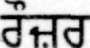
ਰੌਜ਼ਰ
